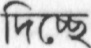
দিচ্ছে
